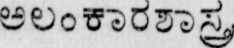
ಅಲಂಕಾರಶಾಸ್ತ್ರ
